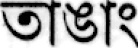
তাঙাং
